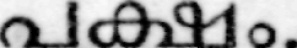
പക്ഷം.
